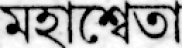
মহাশ্বেতা
